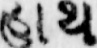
હાથ
